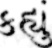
કહ્યું
